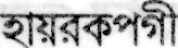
হায়রকপগী
